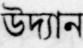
উদ্যান
